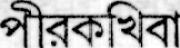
পীরকখিবা
